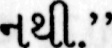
નથી."
